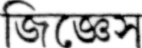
জিজ্ঞেস
